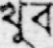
খুব
